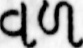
વળ
